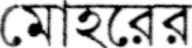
মোহরের
